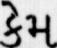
કેમ
